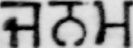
ਜਨਮ
